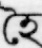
হৈ
